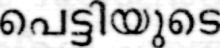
പെട്ടിയുടെ
